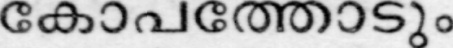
കോപത്തോടും
